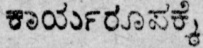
ಕಾರ್ಯರೂಪಕ್ಕೆ
